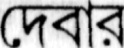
দেবার
